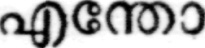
എന്തോ
